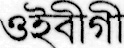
ওইবীগী
